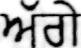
ਅੱਗੇ
